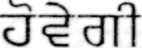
ਹੋਵੇਗੀ
